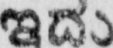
ಇದು
